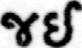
જઈ
